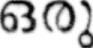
ഒരു
